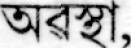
অৱস্হা,
